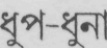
ধুপ-ধুনা
